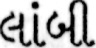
લાંબી
